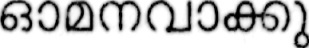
ഓമനവാക്കു
